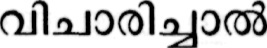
വിചാരിച്ചാല്‍
